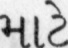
માટે
